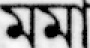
মমা
